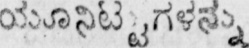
ಯೂನಿಟ್ಟುಗಳನ್ನು
